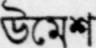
উমেশ
